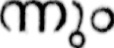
ന്നും
